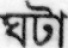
ঘটা
